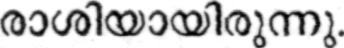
രാശിയായിരുന്നു.
